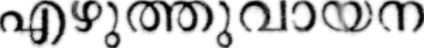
എഴുത്തുവായന
